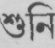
শুনি
